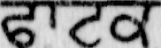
ਫਾਟਕ
